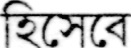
হিসেবে
